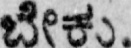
ಬೇಕು.
